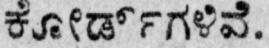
ಕೋರ್ಡ್‌ಗಳಿವೆ.ಯ
